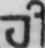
ਹੀ
